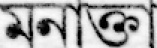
মনাক্তা
